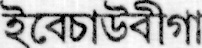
ইবেচাউবীগা
